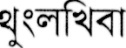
থুংলখিবা
